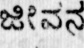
ಜೀವನ
